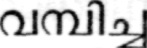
വമ്പിച്ച
